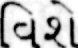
વિશે
